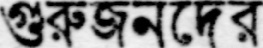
গুরুজনদের
